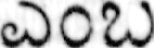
ಎಂಬ
